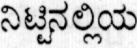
ನಿಟ್ಟಿನಲ್ಲಿಯ
